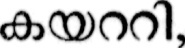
കയററി,
